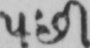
પછી
